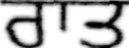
ਰਾਤ
